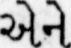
એને
